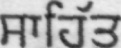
ਸਾਹਿੱਤ
